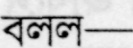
বলল–
